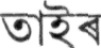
তাইৰ
